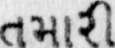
તમારી
